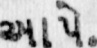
આપે.
